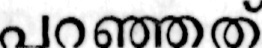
പറഞ്ഞത്
